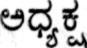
ಅಧ್ಯಕ್ಷ
